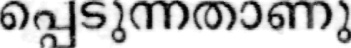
പ്പെടുന്നതാണു
